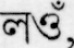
লওঁ,
